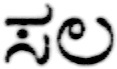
ಸಲ
